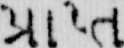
પ્રાપ્ત
